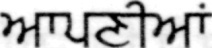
ਆਪਣੀਆਂ
